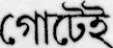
গোটেই
